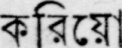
করিয়ো
